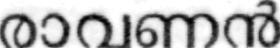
രാവണന്‍
